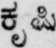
ಕೃಷಿ
